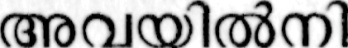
അവയില്‍നി
